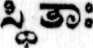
ಸ್ಥಿತಾಃ
